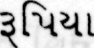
રૂપિયા
